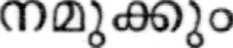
നമുക്കും
